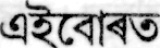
এইবোৰত
